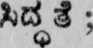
ಸಿದ್ಧತೆ;
